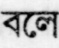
বলে
